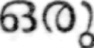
ഒരു
